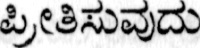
ಪ್ರೀತಿಸುವುದು
